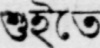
শুইতে
